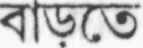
বাড়তে
